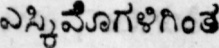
ಎಸ್ಕಿಮೊಗಳಿಗಿಂತ
